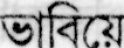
ভাবিয়ে
